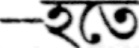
-হতে
